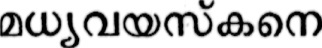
മധ്യവയസ്കനെ
